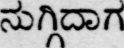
ನುಗ್ಗಿದಾಗ
